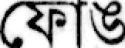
ফোঙ
